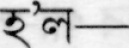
হ'ল-
